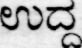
ಉದ್ದ
